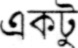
একটু
